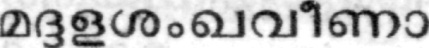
മദ്ദളശംഖവീണാ
